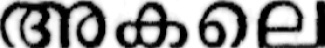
അകലെ
